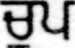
ਚੁਪ
